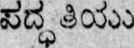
ಪದ್ಧತಿಯು
